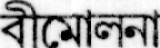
বীমোলনা
